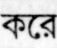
করে
